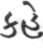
કહે
